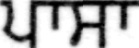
ਪਾਸਾ
